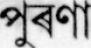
পুৰণা
